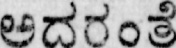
ಅದರಂತೆ
